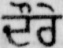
ਦੌਰੇ
